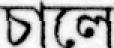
চালে
